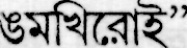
ঙমখিরোই”
